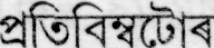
প্রতিবিম্বটোৰ
